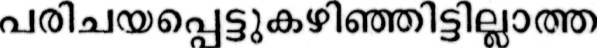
പരിചയപ്പെട്ടുകഴിഞ്ഞിട്ടില്ലാത്ത
